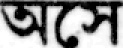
অসে
